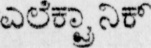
ಎಲೆಕ್ಟ್ರಾನಿಕ್
